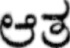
ಆತ
